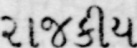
રાજકીય
